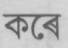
কৰে
